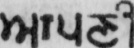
ਆਪਣੀ
